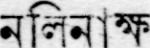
নলিনাক্ষ
